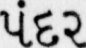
પંદર
